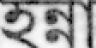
হন্না
